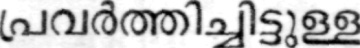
പ്രവര്‍ത്തിച്ചിട്ടുള്ള
